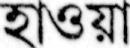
হাওয়া
